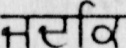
ਜਦਕਿ
